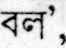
বল’,
